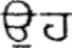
ਉਹ
